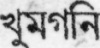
খুমগনি
